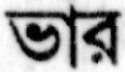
ভার
